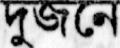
দুজনে
